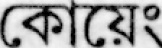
কোয়েং
